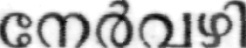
നേര്‍വഴി
